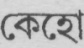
কেহো
